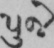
પુજે
